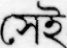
সেই
